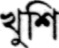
খুশি
